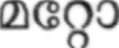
മറ്റോ
